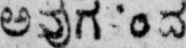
ಅವುಗಳಿಂದ
